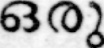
ഒരു
